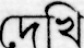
দেখি
